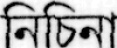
নিচিনা
